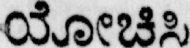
ಯೋಚಿಸಿ
